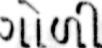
ગોળી
